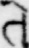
તે
